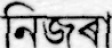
নিজৰা
